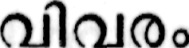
വിവരം
